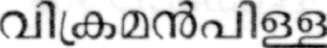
വിക്രമന്‍പിള്ള
